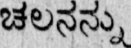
ಚಲನನ್ನು
